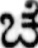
ಚೆ
